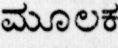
ಮೂಲಕ
